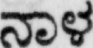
ನಾಳ
